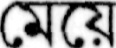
মেয়ে
